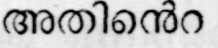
അതിന്റെ
